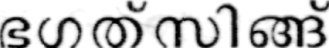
ഭഗത്സിങ്ങ്
